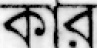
কার
